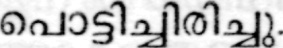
പൊട്ടിച്ചിരിച്ചു.
